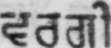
ਵਰਗੀ
